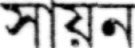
সায়ন
